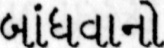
બાંધવાનો
